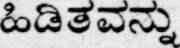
ಹಿಡಿತವನ್ನು
